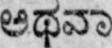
ಅಥವಾ
